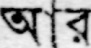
আর
